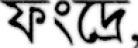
ফংদ্রে,
